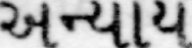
અન્યાય
